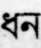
ধন
